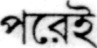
পরেই
